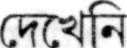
দেখেনি
